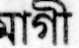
মাগী
